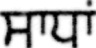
ਸਾਧਾਂ
